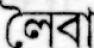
লৈবা
